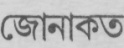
জোনাকত
